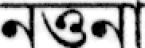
নত্তনা
